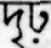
দৃঢ়
